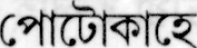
পোটোকাহে
